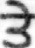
ਤੇ
